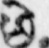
છે.
